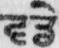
ਵਡੇ
